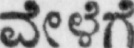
ವೇಳೆಗೆ
